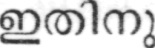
ഇതിനു
